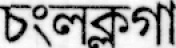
চংলক্লগা
